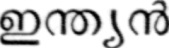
ഇന്ത്യന്‍
